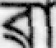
ৱা
